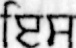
ਇਸ
